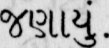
જણાયું.
